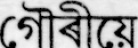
গৌৰীয়ে
